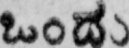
ಒಂದು
